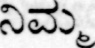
ನಿಮ್ಮ
